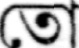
তো
